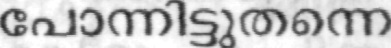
പോന്നിട്ടുതന്നെ
